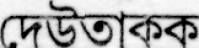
দেউতাকক
